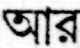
আর
